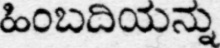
ಹಿಂಬದಿಯನ್ನು
